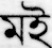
মই
